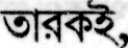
তারকই,
